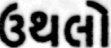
ઉથલો
